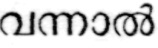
വന്നാല്‍
